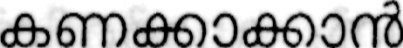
കണക്കാക്കാന്‍
